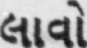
લાવો
